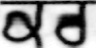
ਕਰ
